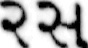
રસ
